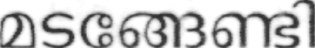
മടങ്ങേണ്ടി
